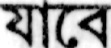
যাবে
